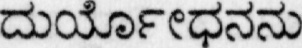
ದುರ್ಯೋಧನನು
